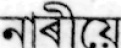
নাৰীয়ে
